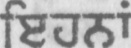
ਇਹਨਾਂ
